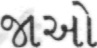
જાઓ
